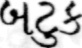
બટુક
